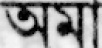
অমা
